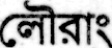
লৌরাং
